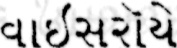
વાઇસરૉયે
